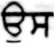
ਉਸ
